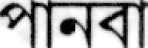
পানবা
